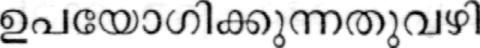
ഉപയോഗിക്കുന്നതുവഴി
